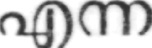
എന്ന
